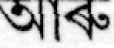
আৰু
